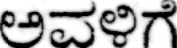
ಅವಳಿಗೆ
